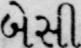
બેસી
